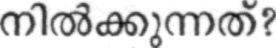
നില്‍ക്കുന്നത്?
